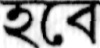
হবে
